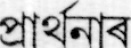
প্রার্থনাৰ
